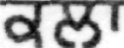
ਕਲਾ
